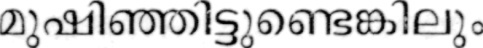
മുഷിഞ്ഞിട്ടുണ്ടെങ്കിലും
